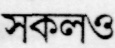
সকলও
